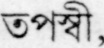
তপস্বী,
